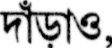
দাঁড়াও,
